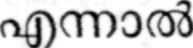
എന്നാല്‍
